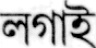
লগাই
